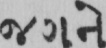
જગને
